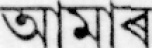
আমাৰ
